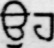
ਉਹ
